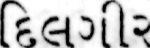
દિલગીર
